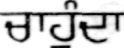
ਚਾਹੁੰਦਾ
